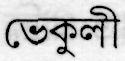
ভেকুলী
